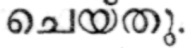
ചെയ്തു.
